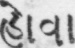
હોવા
